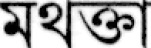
মথক্তা
